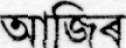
আজিৰ
